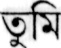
তুমি
